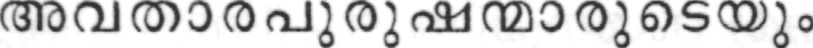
അവതാരപുരുഷന്മാരുടെയും
